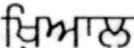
ਖ਼ਿਆਲ
